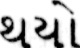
થયો
